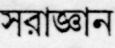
সরাজ্ঞান
